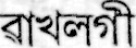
ৱাখলগী
